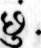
છું.
